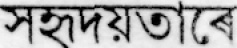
সহৃদয়তাৰে
